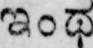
ಇಂಥ
